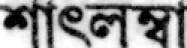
শাৎলম্বা
